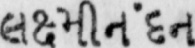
લક્ષ્મીનંદન
